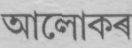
আলোকৰ
